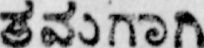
ತಮಗಾಗಿ
